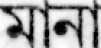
মানা
